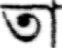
তা
